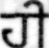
ਹੀ
